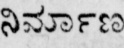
ನಿರ್ಮಾಣ
